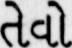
તેવો
